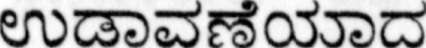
ಉಡಾವಣೆಯಾದ
